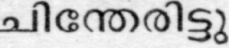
ചിന്തേരിട്ടു
